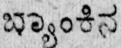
ಬ್ಯಾಂಕಿನ
